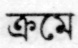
ক্রমে
